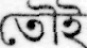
তৌই
